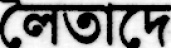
লৈতাদে
